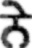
ਨੇ
